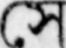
সে
